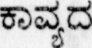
ಕಾವ್ಯದ
